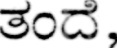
ತಂದೆ,
